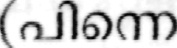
(പിന്നെ
